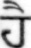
ਹੈ
